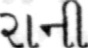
રાની
